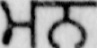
ਮਨ
